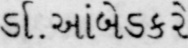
ર્ડા.આંબેડકરે
